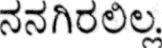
ನನಗಿರಲಿಲ್ಲ.
